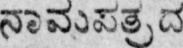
ನಾಮಪತ್ರದ
